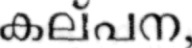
കല്പന,
